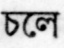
চলে
